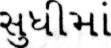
સુધીમાં
